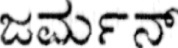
ಜರ್ಮನ್
